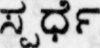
ಸ್ಪರ್ಧೆ
